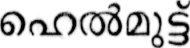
ഹെല്‍മുട്ട്
